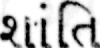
શાંતિ
